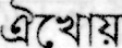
ঐখোয়
